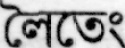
লৈতেং
